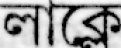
লাক্লে
